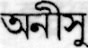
অনীসু
